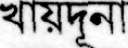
খায়দূনা
